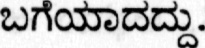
ಬಗೆಯಾದದ್ದು.
